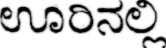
ಊರಿನಲ್ಲಿ
